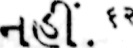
નહી.૬૨
